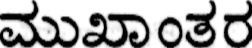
ಮುಖಾಂತರ
